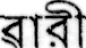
ৱারী
